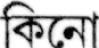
কিনো
